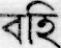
বহি
